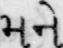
મને
